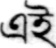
এই
